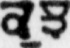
ਕੁਝ
